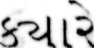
ક્યારે
